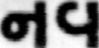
નવ
